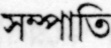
সম্পাতি
